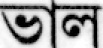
ভাল
